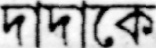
দাদাকে
